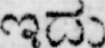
ಇದು
